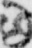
છે
